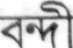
বন্দী
